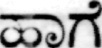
ಹಾಗೆ
